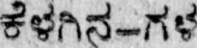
ಕೆಳಗಿನ-ಗಳ
